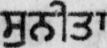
ਸੁਨੀਤਾ
